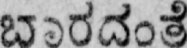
ಬಾರದಂತೆ
